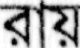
রায়
